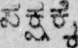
ಪಕ್ಷಕ್ಕೆ
